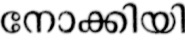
നോക്കിയി
